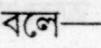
বলে–
